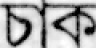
চাক
